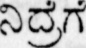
ನಿದ್ರೆಗೆ
